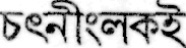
চৎনীংলকই
